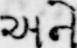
અને
